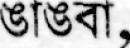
ঙাঙবা,
